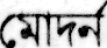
মোর্দন
